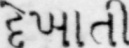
દેખાતી
